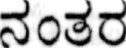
ನಂತರ
